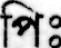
পিঃ
